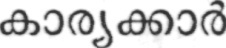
കാര്യക്കാര്‍
